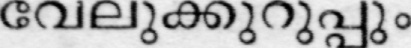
വേലുക്കുറുപ്പും
